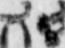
ಗಳ
